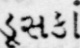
ડૂસકાં
